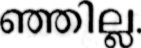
ഞ്ഞില്ല.
